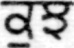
ਕੁਝ
